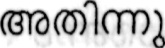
അതിന്നു
